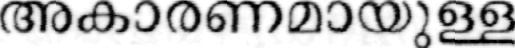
അകാരണമായുള്ള
